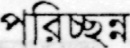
পরিচ্ছন্ন
